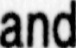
and
